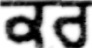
ਕਰ
